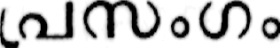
പ്രസംഗം
